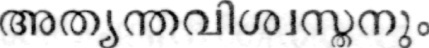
അത്യന്തവിശ്വസ്തനും
